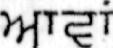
ਆਵਾਂ
